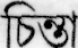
চিন্তা
